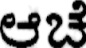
ಆಚೆ
